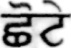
ਛੋਟੇ
